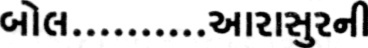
બોલ...........આરાસુરની
